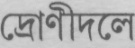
দ্ৰোণীদলে
